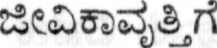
ಜೀವಿಕಾವೃತ್ತಿಗೆ
